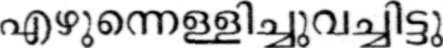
എഴുന്നെള്ളിച്ചുവച്ചിട്ടു
